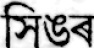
সিঙৰ
